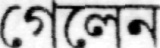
গেলেন
